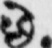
છે.
